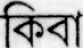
কিবা
